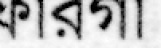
ফারগা
